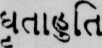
ધતાહુતિ
